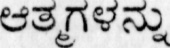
ಆತ್ಮಗಳನ್ನು
